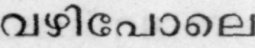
വഴിപോലെ
